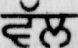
ਵੱਲ
